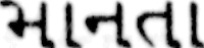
માનતા
